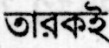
তারকই
